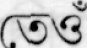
তেওঁ
